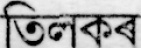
তিলকৰ
